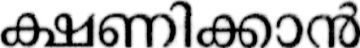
ക്ഷണിക്കാന്‍
